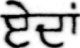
ਏਦਾਂ
